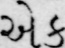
એક
